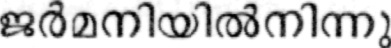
ജര്‍മനിയില്‍നിന്നു
